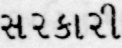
સરકારી
